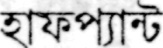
হাফপ্যান্ট
